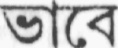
ভাবে
